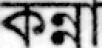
কন্না
